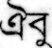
ঐবু
